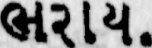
ભરાય.
